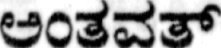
ಅಂತವತ್
